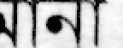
মানা
